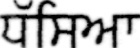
ਧੱਸਿਆ
